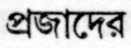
প্রজাদের
